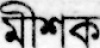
মীশক
